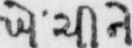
ખેંચીને
